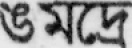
ঙমদ্রে
